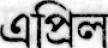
এপ্রিল
